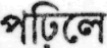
পঢ়িলে
